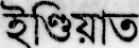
ইণ্ডিয়াত
